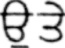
ਉਤੇ
